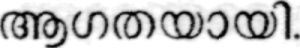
ആഗതയായി.
